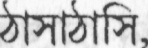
ঠাসাঠাসি,
